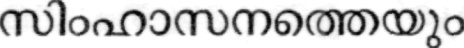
സിംഹാസനത്തെയും
